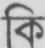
কি
